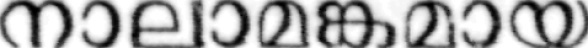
നാലാമങ്കമായ
